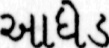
આધેડ
